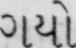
ગયો
